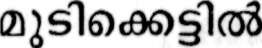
മുടിക്കെട്ടില്‍
